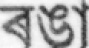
ৰঙা
